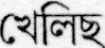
খেলিছ
